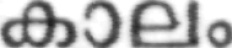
കാലം
